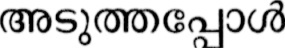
അടുത്തപ്പോള്‍
